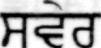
ਸਵੇਰ
